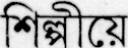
শিল্পীয়ে
